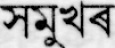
সমুখৰ
